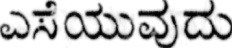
ಎಸೆಯುವುದು
